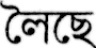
লৈছে
